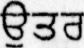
ਉਤਰ
